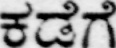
ಕಡೆಗೆ
